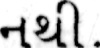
નથી.
